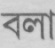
বলা
